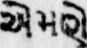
એમણે
